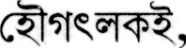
হৌগৎলকই,
